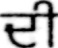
ਦੀ
